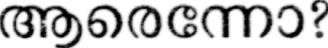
ആരെന്നോ?
